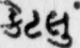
કેટલું
